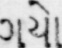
ગયો
